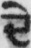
ਦੇ
